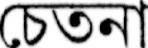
চেতনা
